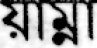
য়াম্না
